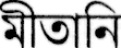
মীতানি
